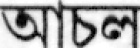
আচল
